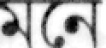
মনে
